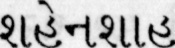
શહેનશાહ
